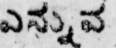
ಎನ್ನುವ
